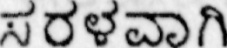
ಸರಳವಾಗಿ
